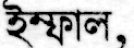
ইম্ফাল,
